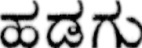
ಹಡಗು
